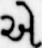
એ
